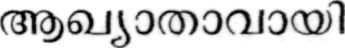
ആഖ്യാതാവായി
